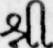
શ્રી
